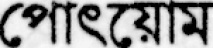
পোৎয়োম
